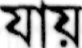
যায়
